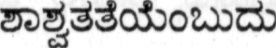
ಶಾಶ್ವತತೆಯೆಂಬುದು
